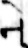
ને
